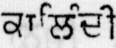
ਕਾਲਿੰਦੀ
